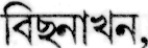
বিছনাখন,
